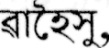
ৱাহৈসু,
